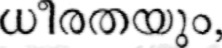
ധീരതയും,
